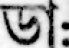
ডা:
